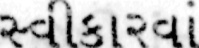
સ્વીકારવાં
